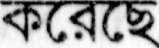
করেছে
